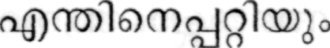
എന്തിനെപ്പറ്റിയും
